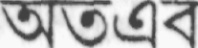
অতএব
